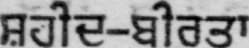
ਸ਼ਹੀਦ-ਬੀਰਤਾ
